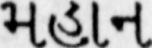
મહાન
